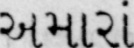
અમારાં
